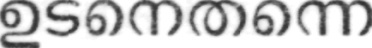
ഉടനെതന്നെ
